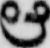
ಆ
